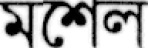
মশেল
